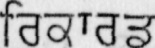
ਰਿਕਾਰਡ
